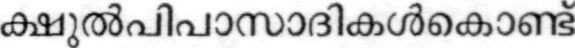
ക്ഷുല്‍പിപാസാദികള്‍കൊണ്ട്
